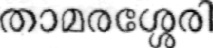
താമരശ്ശേരി
